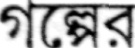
গল্পের
